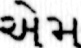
એમ
